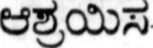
ಆಶ್ರಯಿಸ
